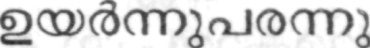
ഉയര്‍ന്നുപരന്നു
